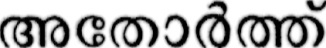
അതോര്‍ത്ത്
